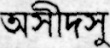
অসীদসু
